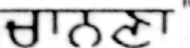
ਚਾਨਣਾ''
